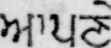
ਆਪਣੇ
